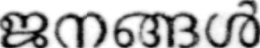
ജനങ്ങള്‍
